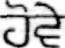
ਹੋਵੇ
